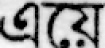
এয়ে
